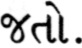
જતો.
